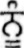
ਨੂੰ
